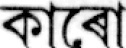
কাৰো
